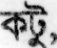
কটু,
